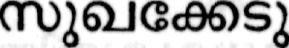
സുഖക്കേടു
